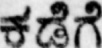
ಕಡೆಗೆ
